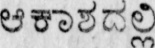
ಆಕಾಶದಲ್ಲಿ
